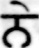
ਨੇ
